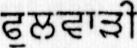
ਫੁਲਵਾੜੀ
